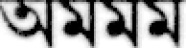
অমমম
